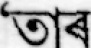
'তাৰ
